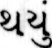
થયું
